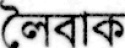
লৈবাক
